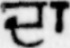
ਦਾ
